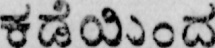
ಕಡೆಯಿಂದ
